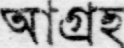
আগ্রহ
